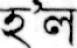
হ'ল
